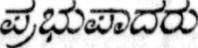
ಪ್ರಭುಪಾದರು
